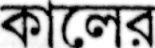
কালের
